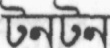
টনটন
